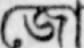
জো
